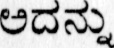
ಅದನ್ನು
